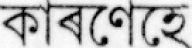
কাৰণেহে
